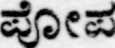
ಪೋಪ
